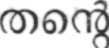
തന്റെ
